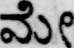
ಮೇ
